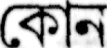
কোন
